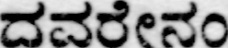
ದವರೇನಂ
